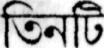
তিনটি
